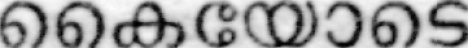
കൈയോടെ
